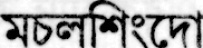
মচলশিংদো
